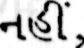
નહીં,
